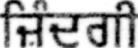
ਜ਼ਿਦਗੀ
